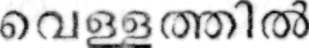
വെള്ളത്തില്‍
